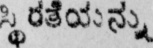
ಸ್ಥಿರತೆಯನ್ನು
